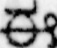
ಈ
